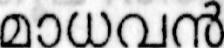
മാധവന്‍
